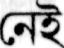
নেই
